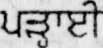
ਪੜ੍ਹਾਈ
